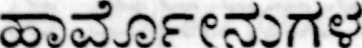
ಹಾರ್ಮೋನುಗಳ
